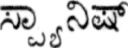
ಸ್ಪ್ಯಾನಿಷ್
